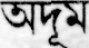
অদূম
